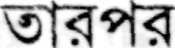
তারপর
